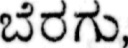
ಬೆರಗು,
